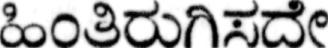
ಹಿಂತಿರುಗಿಸದೇ
